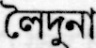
লৈদুনা
